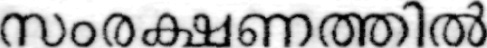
സംരക്ഷണത്തില്‍
